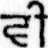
ਵੀ
